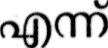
എന്ന്
